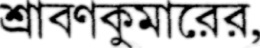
শ্রাবণকুমারের,
